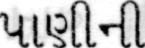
પાણીની
